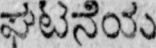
ಘಟನೆಯ
